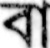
বা
